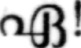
ഏ!
